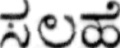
ಸಲಹೆ
